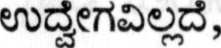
ಉದ್ವೇಗವಿಲ್ಲದೆ,
